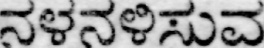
ನಳನಳಿಸುವ
